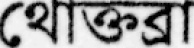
থোক্তব্রা
